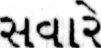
સવારે
